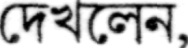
দেখলেন,
